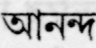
আনন্দ
